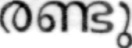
രണ്ടു
